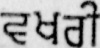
ਵਖਰੀ
